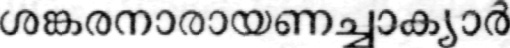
ശങ്കരനാരായണച്ചാക്യാര്‍
